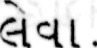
લેવા.
